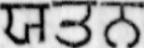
ਯਤਨ
